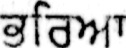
ਭਰਿਆ
